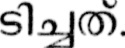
ടിച്ചത്.
